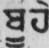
ਬੂਹੇ
